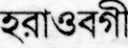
হরাওবগী
